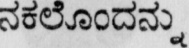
ನಕಲೊಂದನ್ನು
